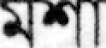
মশা
